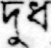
দুধ
